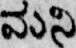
ಮನಿ
